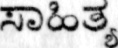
ಸಾಹಿತ್ಯ
